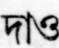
দাও
